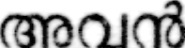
അവന്‍
